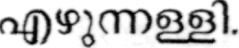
എഴുന്നള്ളി.
